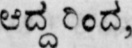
ಆದ್ದರಿಂದ,
